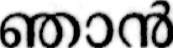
ഞാന്‍
